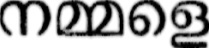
നമ്മളെ
